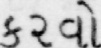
કરવો
